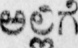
ಅಲ್ಲಿಗೆ
